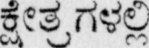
ಕ್ಷೇತ್ರಗಳಲ್ಲಿ
